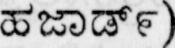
ಹಜಾರ್ಡ್)
